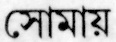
সোমায়
